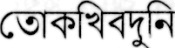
তোকখিবদুনি
